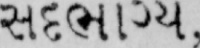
સદભાગ્ય,
